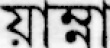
য়াম্না
